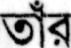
তাঁর
